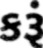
કરૂં
